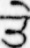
ਤੇ
